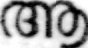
ആ
